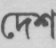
দেশ
